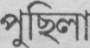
পুছিলা
